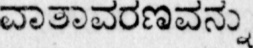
ವಾತಾವರಣವನ್ನು
